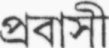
প্রবাসী
